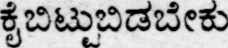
ಕೈಬಿಟ್ಟುಬಿಡಬೇಕು
